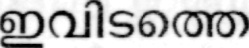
ഇവിടത്തെ
